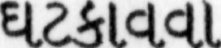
ઘટકાવવા
